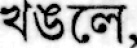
খঙলে,
